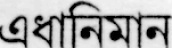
এধানিমান
